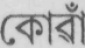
কোৱাঁ
